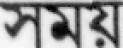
সময়
